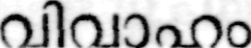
വിവാഹം
